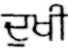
ਦੁਖੀ
